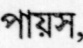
পায়স,
